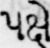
પક્ષે
